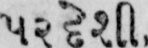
પરદેશી.
